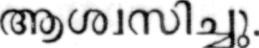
ആശ്വസിച്ചു.
